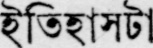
ইতিহাসটা
